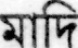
মাদি
